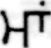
ਮਾਂ
